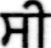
ਸੀ
